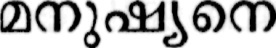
മനുഷ്യനെ
